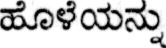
ಹೊಳೆಯನ್ನು
